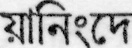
য়ানিংদে
